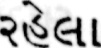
રહેલા
